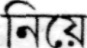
নিয়ে
